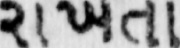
રાખતા
